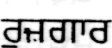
ਰੁਜ਼ਗਾਰ
